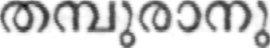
തമ്പുരാനു
